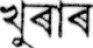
খুৰাৰ
